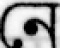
নে
